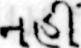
નહીં
